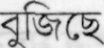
বুজিছে
